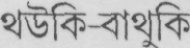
থউকি-বাথুকি
